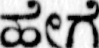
ಹೇಗೆ
